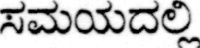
ಸಮಯದಲ್ಲಿ
